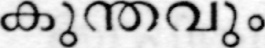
കുന്തവും
